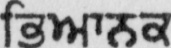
ਭਿਆਨਕ
